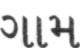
ગામ
